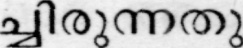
ച്ചിരുന്നതു
